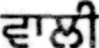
ਵਾਲੀ
